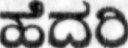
ಹೆದರಿ
